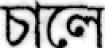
চালে
